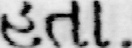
હતા.
